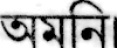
অমনি।
